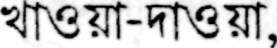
খাওয়া-দাওয়া,
